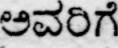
ಅವರಿಗೆ
